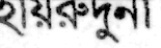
হায়রুদুনা
